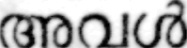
അവള്‍
